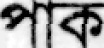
পাক
